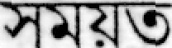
সময়ত
